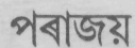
পৰাজয়
